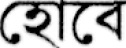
হোবে
